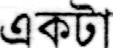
একটা
